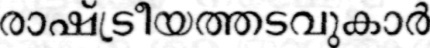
രാഷ്ട്രീയത്തടവുകാര്‍
